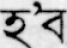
হ'ব
